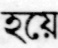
হয়ে
